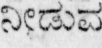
ನೀಡುವ
